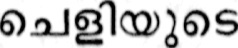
ചെളിയുടെ
